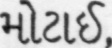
મોટાઈ,
